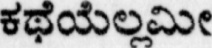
ಕಥೆಯೆಲ್ಲಮೀ
